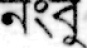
নংবু
